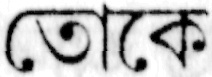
তোকে
